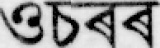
ওচৰৰ
